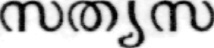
സത്യസ
